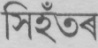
সিহঁতৰ
